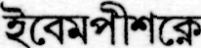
ইবেমপীশক্নে
